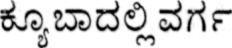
ಕ್ಯೂಬಾದಲ್ಲಿವರ್ಗ
